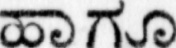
ಹಾಗೂ
